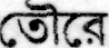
তৌরে
